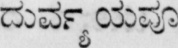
ದುರ್ವ್ಯಯವೂ
